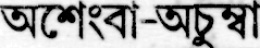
অশেংবা-অচুম্বা
